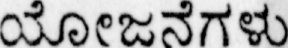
ಯೋಜನೆಗಳು
